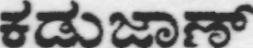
ಕಡುಜಾಣ್
